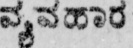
ವ್ಯವಹಾರ
